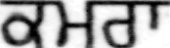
ਕਮਰਾ
